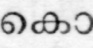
കൊ
